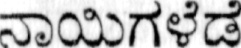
ನಾಯಿಗಳೆಡೆ
